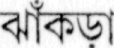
ঝাঁকড়া
